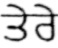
ਤੇਰੇ
